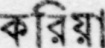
করিয়া
